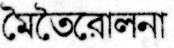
মৈতৈরোলনা
